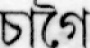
চাগৈ
